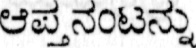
ಆಪ್ತನಂಟನ್ನು
